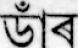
ডাঁৰ
